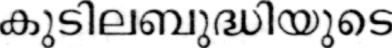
കുടിലബുദ്ധിയുടെ
